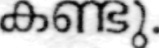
കണ്ടു.
